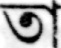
তা
